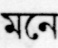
মনে
